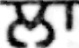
ਲਾ
